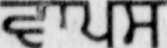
ਵਾਪਸ
